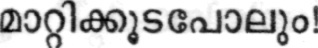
മാറ്റിക്കൂടപോലും!
